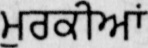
ਮੁਰਕੀਆਂ
